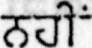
ਨਹੀਂ
